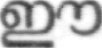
ഈ
